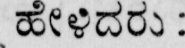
ಹೇಳಿದರು:
